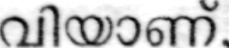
വിയാണ്,
